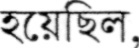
হয়েছিল,
